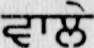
ਵਾਲੇ
